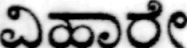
ವಿಹಾರೇ
